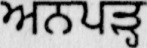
ਅਨਪੜ੍ਹ
